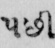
પછી
